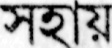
সহায়
